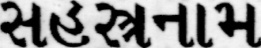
સહસ્ત્રનામ
